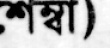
শেম্বা)
